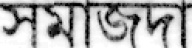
সমাজদা
